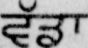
ਵੱਡਾ
